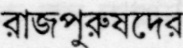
রাজপুরুষদের
